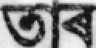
তাৰ
